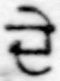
ਦੇ
